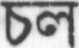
চল
